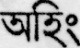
অহিং
